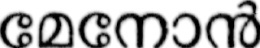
മേനോന്‍
